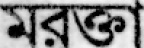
মরক্তা
